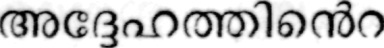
അദ്ദേഹത്തിന്റെ
